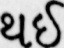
થઈ
